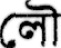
লৌ
